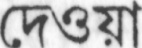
দেওয়া
